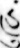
હું
